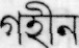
গহীন
